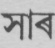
সাৰ
